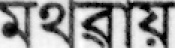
মথৱায়
